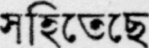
সহিতেছে
